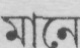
মানে
